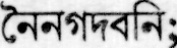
নৈনগদবনি;
